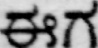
ಈಗ
